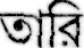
তারি
